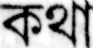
কথা
